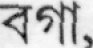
বগা,
